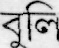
বুলি
